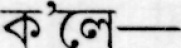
ক'লে-
